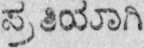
ಪ್ರತಿಯಾಗಿ
